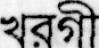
খরগী
